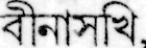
বীনাসখি,
